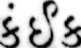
કંઈક
